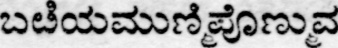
ಬೞಿಯಮುಣ್ಮಿಪೊಣ್ಮುವ
